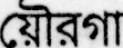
য়ৌরগা
